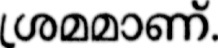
ശ്രമമാണ്.
